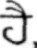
ਹੈ,
